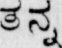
ತನ್ನ
